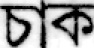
চাক
